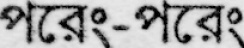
পরেং-পরেং
